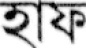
হাফ
